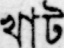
খাট
